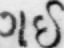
ગઈ
